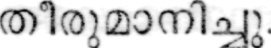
തീരുമാനിച്ചു.
